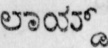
ಲಾಯ್ಡ್
